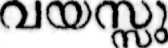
വയസ്സു
